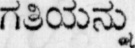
ಗತಿಯನ್ನು
